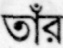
তাঁর
